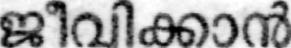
ജീവിക്കാന്‍
